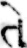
તે
